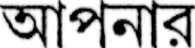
আপনার
